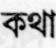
কথা
